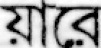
য়ারে
